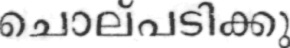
ചൊല്പടിക്കു
